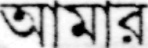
আমার
